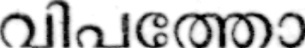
വിപത്തോ
